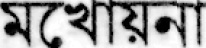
মখোয়না
